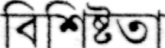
বিশিষ্টতা
